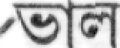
ভাল
